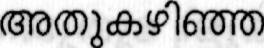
അതുകഴിഞ്ഞ
